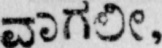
ವಾಗಲೀ,
